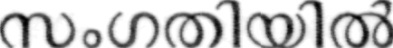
സംഗതിയില്‍
